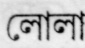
লোলা
